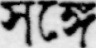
সঙ্গে
